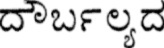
ದೌರ್ಬಲ್ಯದ
